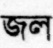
জল
